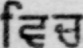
ਵਿਚ
